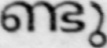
ണ്ടു
